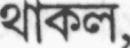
থাকল,
